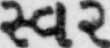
સ્વર
